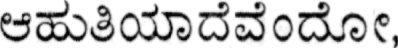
ಆಹುತಿಯಾದೆವೆಂದೋ,
